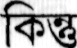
কিন্তু
